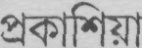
প্ৰকাশিয়া
